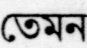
তেমন
